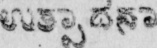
ಉತ್ಪಾದನಾ
